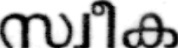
സ്വീക
